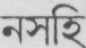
নসহি
